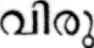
വിരു
